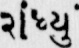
રાંધ્યું
